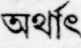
অর্থাত্
